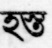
হস্ত
